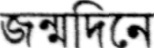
জন্মদিনে
